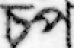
চপ
